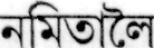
নমিতালৈ
